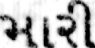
મારી
